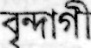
বৃন্দাগী
